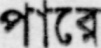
পারে
